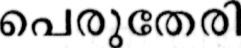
പെരുതേരി
